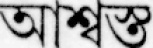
আশ্বস্ত
